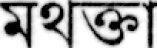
মথক্তা
